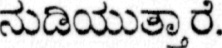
ನುಡಿಯುತ್ತಾರೆ.
